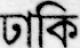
ঢাকি
